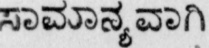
ಸಾಮಾನ್ಯವಾಗಿ
